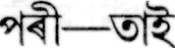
পৰী-তাই
